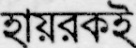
হায়রকই
